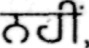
ਨਹੀਂ,
